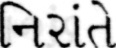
નિરાંતે
